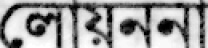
লোয়ননা
